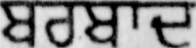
ਬਰਬਾਦ
